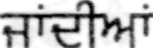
ਜਾਂਦੀਆਂ
